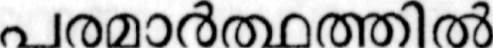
പരമാര്‍ത്ഥത്തില്‍
